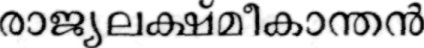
രാജ്യലക്ഷ്മീകാന്തന്‍
